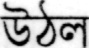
উঠল
